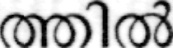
ത്തില്‍
